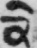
ਕੇ
